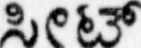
ಸೀಟ್
